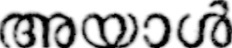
അയാള്‍
